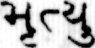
મૃત્યુ
